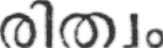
രിത്വം
